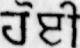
ਹੋਈ
